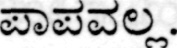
ಪಾಪವಲ್ಲ.
